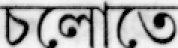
চলোতে
